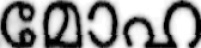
മോഹ
